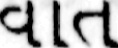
વાત
